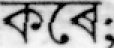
কৰে;
